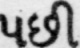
પછી
